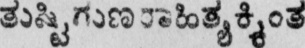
ತುಷ್ಟಿಗುಣರಾಹಿತ್ಯಕ್ಕಿಂತ
